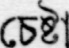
চেষ্টা
